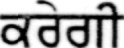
ਕਰੇਗੀ
